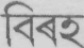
বিৰহ
